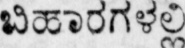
ಬಿಹಾರಗಳಲ್ಲಿ
